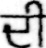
ਦੀ
